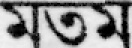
মতম
